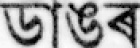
ডাঙৰ
